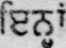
ਇਨ੍ਹਾਂ
